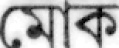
মোক
